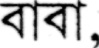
বাবা,
